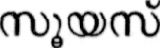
സൂയസ്
